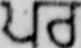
ਪਰ
